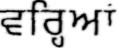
ਵਰ੍ਹਿਆਂ
